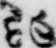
દેહ
